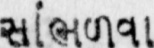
સાંભળવા
